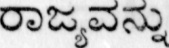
ರಾಜ್ಯವನ್ನು
